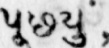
પૂછ્યું,
